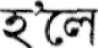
হ'লে
